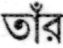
তাঁর
